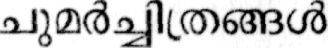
ചുമര്‍ച്ചിത്രങ്ങള്‍
